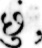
છું,
